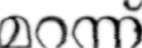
മറന്ന്
